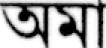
অমা
